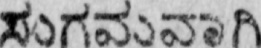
ಸುಗಮವಾಗಿ
